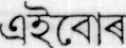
এইবোৰ
